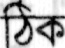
ঠিক
